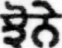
ਝੋਨੇ
